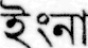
ইংনা
